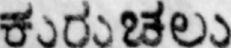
ಕುರುಚಲು
